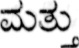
ಮತ್ತು
